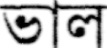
ভাল
